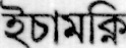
ইচামক্নি
